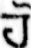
ਹੋ
